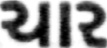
ચાર
